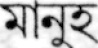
মানুহ
